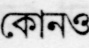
কোনও
